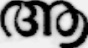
ആ
